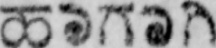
ಹಾಗಾಗಿ
